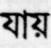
যায়
